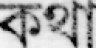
কথা
